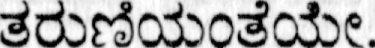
ತರುಣಿಯಂತೆಯೇ.
